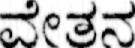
ವೇತನ
